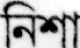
নিশা
